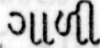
ગાળી
